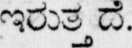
ಇರುತ್ತದೆ.
